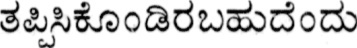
ತಪ್ಪಿಸಿಕೊಂಡಿರಬಹುದೆಂದು
